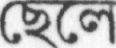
ছেলে
